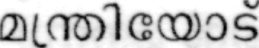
മന്ത്രിയോട്
